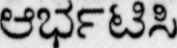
ಆರ್ಭಟಿಸಿ
